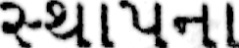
સ્થાપના
